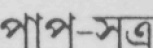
পাপ-সত্ৰ
